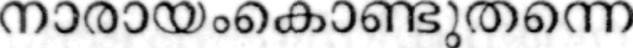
നാരായംകൊണ്ടുതന്നെ
